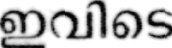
ഇവിടെ
